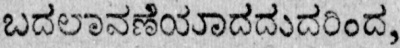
ಬದಲಾವಣೆಯಾದದುದರಿಂದ,
